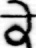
ਕੇ
